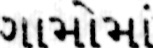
ગામોમાં
